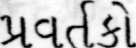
પ્રવર્તકો
